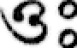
ওঃ
